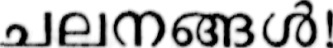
ചലനങ്ങള്‍!
